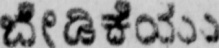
ಬೇಡಿಕೆಯು
